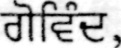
ਗੋਵਿੰਦ,
